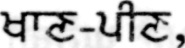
ਖਾਣ-ਪੀਣ,
